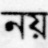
নয়
